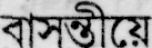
বাসন্তীয়ে
